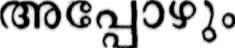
അപ്പോഴും
